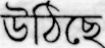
উঠিছে
